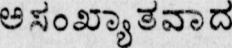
ಅಸಂಖ್ಯಾತವಾದ
